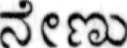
ನೇಣು
